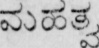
ಮಹತ್ವ
